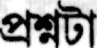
প্রশ্নটা
